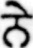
ਨੇ
